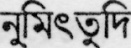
নুমিৎতুদি
